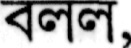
বলল,
